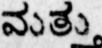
ಮತ್ತು
